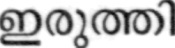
ഇരുത്തി
